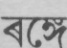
ৰঙ্গে
